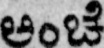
ಅಂಚೆ
